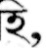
হি,
